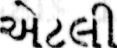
એટલી
